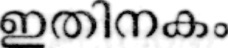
ഇതിനകം
